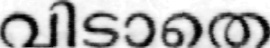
വിടാതെ
